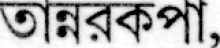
তান্নরকপা,
